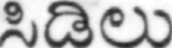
ಸಿಡಿಲು
